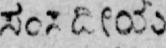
ಸಂಸದೀಯ
